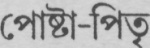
পোষ্টা-পিতৃ
